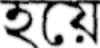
হয়ে
